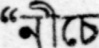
‘‘নীচে
